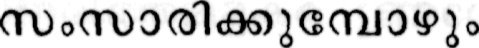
സംസാരിക്കുമ്പോഴും
